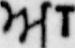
ਆ
